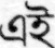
এই
